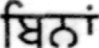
ਬਿਨਾਂ
